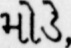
મોડે,
